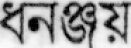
ধনঞ্জয়
